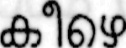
കീഴെ
